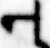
ન
